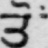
ਤੋਂ
